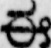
ಈ
